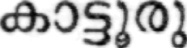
കാട്ടൂരു
